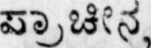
ಪ್ರಾಚೀನ,
